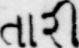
તારી
